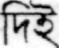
দিই
